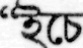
“ইচে
